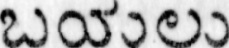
ಬಯಲು
